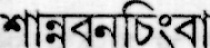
শান্নবনচিংবা
